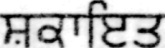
ਸ਼ਕਾਇਤ
